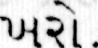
ખરો.
